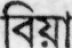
বিয়া
